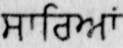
ਸਾਰਿਆਂ
